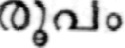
രൂപം
